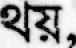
থয়,
